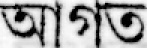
আগত
